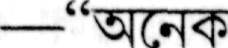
-"অনেক
